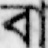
বা
